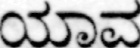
ಯಾವ
